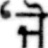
'ਜੋ
